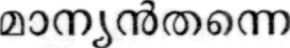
മാന്യന്‍തന്നെ
